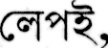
লেপই,
